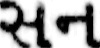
સન
